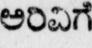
ಅರಿವಿಗೆ
